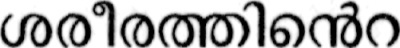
ശരീരത്തിന്റെ
